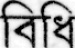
বিধি
